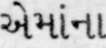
એમાંના
